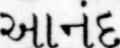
આનંદ
